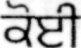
ਕੋਈ
